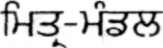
ਮਿਤ੍ਰ-ਮੰਡਲ
